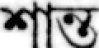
শান্ত
